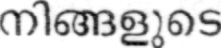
നിങ്ങളുടെ
